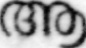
ആ
